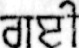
ਗਈ
